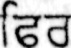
ਫਿਰ
